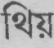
থিয়
